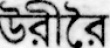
উরীরৈ
